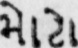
મોટો
